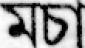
মচা
